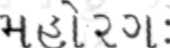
મહોરગઃ
